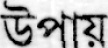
উপায়
